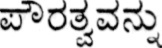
ಪೌರತ್ವವನ್ನು
